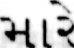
મારે
